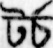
টর্চ
